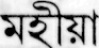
মহীয়া
